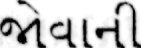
જોવાની
